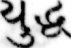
યુદ્ધ
